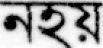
নহয়
